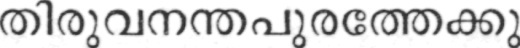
തിരുവനന്തപുരത്തേക്കു
